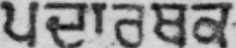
ਪਦਾਰਥਕ
